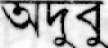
অদুবু
